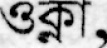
ওক্না,
